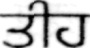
ਤੀਹ
